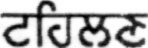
ਟਹਿਲਣ
